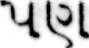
પણ
